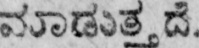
ಮಾಡುತ್ತದೆ.
